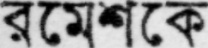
রমেশকে
